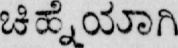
ಚಿಹ್ನೆಯಾಗಿ
